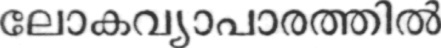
ലോകവ്യാപാരത്തില്‍
